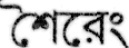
শৈরেং
